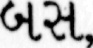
બસ,
